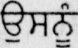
ਉਸਨੂੰ
